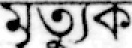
মৃত্যুক
